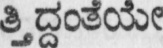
ತ್ತಿದ್ದಂತೆಯೇ
